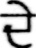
ਦੇ
